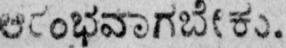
ಆರಂಭವಾಗಬೇಕು.
